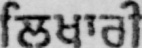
ਲਿਖਾਰੀ
